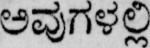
ಅವುಗಳಲ್ಲಿ
